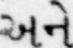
અને
